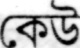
কেউ
